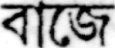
বাজে
